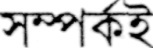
সম্পর্কই
